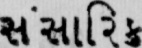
સંસારિક
